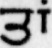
ਤਾਂ
